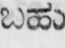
ಬಹು
